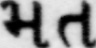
મત
